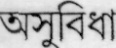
অসুবিধা
